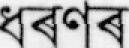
ধৰণৰ
